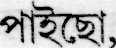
পাইছো,
